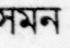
সমন
